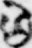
છે
